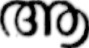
ആ
